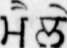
ਮੈਲੇ
